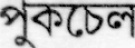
পুকচেল
